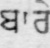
ਬਾਰੇ
